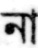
না
